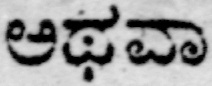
ಅಥವಾ
